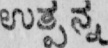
ಉತ್ಪನ್ನ
